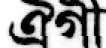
ঐগী
